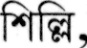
শিল্লি,
